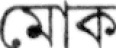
মোক
